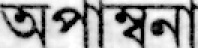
অপাম্বনা
